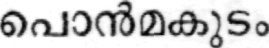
പൊന്‍മകുടം
